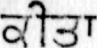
ਕੀਤਾ
